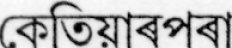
কেতিয়াৰপৰা
